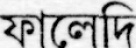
ফালেদি
